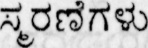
ಸ್ಮರಣೆಗಳು
